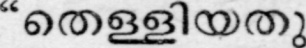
"തെള്ളിയതു
